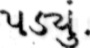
પડ્યું.
